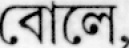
বোলে,
